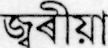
জ্বৰীয়া
